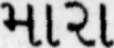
મારા
